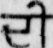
ਦੀ
